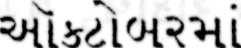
ઑક્ટોબરમાં
